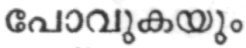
പോവുകയും
